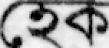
হেক
